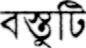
বস্তুটি
